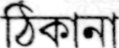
ঠিকানা
